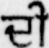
ਦੀ
